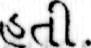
હતી.
